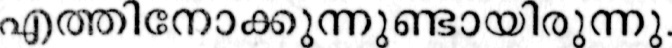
എത്തിനോക്കുന്നുണ്ടായിരുന്നു.
